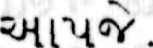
આપજે.
